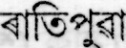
ৰাতিপুৱা
